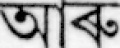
আৰু
